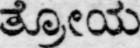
ತ್ರೋಯ
